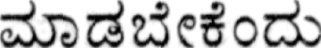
ಮಾಡಬೇಕೆಂದು
